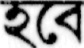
হবে
